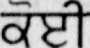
ਕੋਈ
